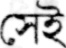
সেই
